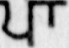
ਪਾ
